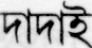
দাদাই
